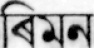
ৰিমন
